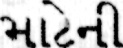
માટેની
